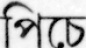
পিচে
